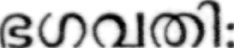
ഭഗവതി:
